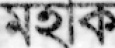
মহাক
